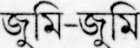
জুমি-জুমি
